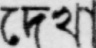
দেখা
